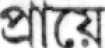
প্রায়ে
